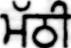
ਮੱਠੀ
